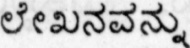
ಲೇಖನವನ್ನು
